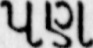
પણ
